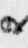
જ
